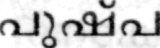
പുഷ്പ
